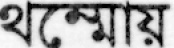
থম্মোয়
